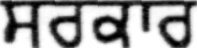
ਸਰਕਾਰ
